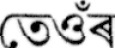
তেওঁৰ
